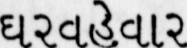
ઘરવહેવાર
